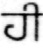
ਹੀ
